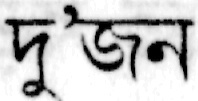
দু'জন
